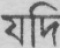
যদি
